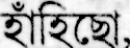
হাঁহিছো,
